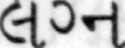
લગ્ન
